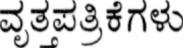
ವೃತ್ತಪತ್ರಿಕೆಗಳು
